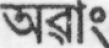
অৱাং
